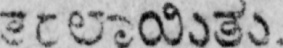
ತರಲಾಯಿತು.
